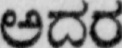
ಅದರ
